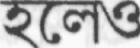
হলেও
